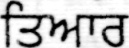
ਤਿਆਰ
